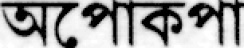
অপোকপা
